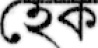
হেক
